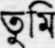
তুমি
